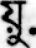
য়ু.
